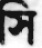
সি
